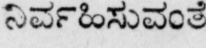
ನಿರ್ವಹಿಸುವಂತೆ
